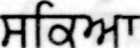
ਸਕਿਆ
